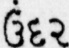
ઉંદર
